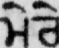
ਮੇਰੇ
